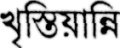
খৃস্তিয়ান্নি
